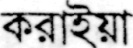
করাইয়া
